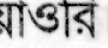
য়াওরি
